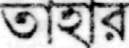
তাহার
